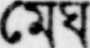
মেঘ
